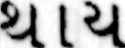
થાય
